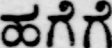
ಹಗೆಗೆ
